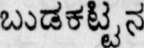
ಬುಡಕಟ್ಟಿನ
